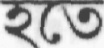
হতে
